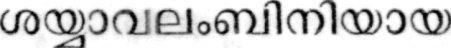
ശയ്യാവലംബിനിയായ
